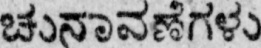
ಚುನಾವಣೆಗಳು
